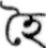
হৈ
